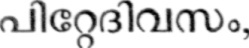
പിറ്റേദിവസം,
